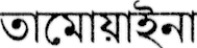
তামোয়াইনা
